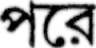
পরে
